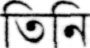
তিনি
